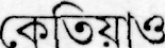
কেতিয়াও
